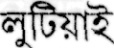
লুটিয়াই
